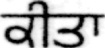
ਕੀਤਾ
